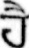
ਹੈ
